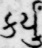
કર્યું
